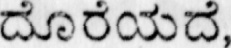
ದೊರೆಯದೆ,
